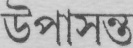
উপাসন্ত
